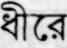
ধীরে
